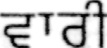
ਵਾਰੀ
